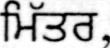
ਮਿੱਤਰ,
